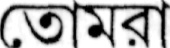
তোমরা
